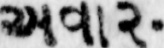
અવાર
